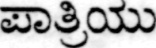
ಪಾತ್ರಿಯು
